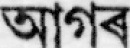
আগৰ
